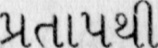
પ્રતાપથી
